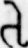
તે
